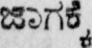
ಜಾಗಕ್ಕೆ
